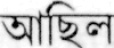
আছিল
